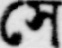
সে
